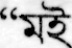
"মই
